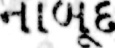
નાબૂદ
